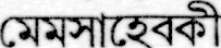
মেমসাহেবকী
